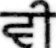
ਵੀ
